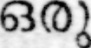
ഒരു
